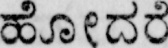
ಹೋದರೆ
